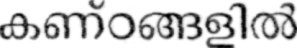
കണ്ഠങ്ങളില്‍
